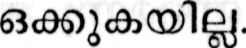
ഒക്കുകയില്ല.
